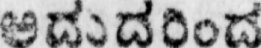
ಆದುದರಿಂದ
